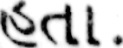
હતા.
